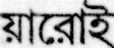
য়ারোই
